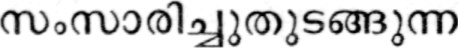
സംസാരിച്ചുതുടങ്ങുന്ന
